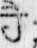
ਹੈ;
